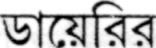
ডায়েরির
